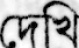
দেখি
